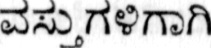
ವಸ್ತುಗಳಿಗಾಗಿ
